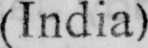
(India)
